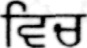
ਵਿਚ
